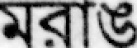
মরাঙ
